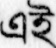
এই
